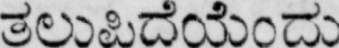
ತಲುಪಿದೆಯೆಂದು
